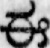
ಈ
